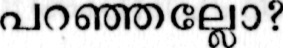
പറഞ്ഞല്ലോ?
